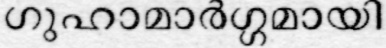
ഗുഹാമാര്‍ഗ്ഗമായി
